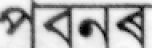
পবনৰ
